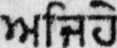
ਅਜਿਹੇ
